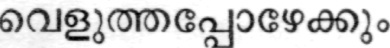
വെളുത്തപ്പോഴേക്കും
